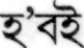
হ'বই
